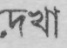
দেখা
